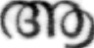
ആ
